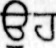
ਉਹ
